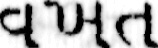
વખત
